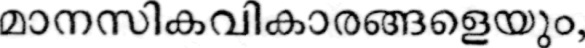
മാനസികവികാരങ്ങളെയും,
